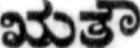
ಋತೌ
